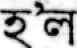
হ'ল
